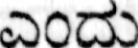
ಎಂದು
